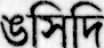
ঙসিদি
